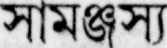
সামঞ্জস্য
